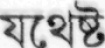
যথেষ্ট
